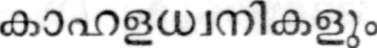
കാഹളധ്വനികളും
